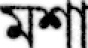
মশা
